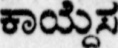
ಕಾಯ್ದೆಸ
